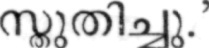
സ്തുതിച്ചു.'
